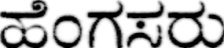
ಹೆಂಗಸರು
